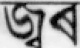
জ্বৰ
